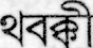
থবক্কী
